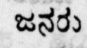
ಜನರು
